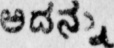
ಅದನ್ನು
